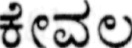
ಕೇವಲ
